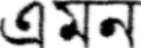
এমন
